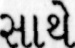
સાથે
